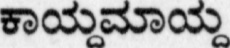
ಕಾಯ್ದಮಾಯ್ದ
